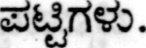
ಪಟ್ಟಿಗಳು.
